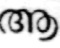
ആ
